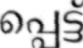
പ്പെട്ട്
